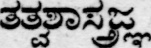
ತತ್ವಶಾಸ್ತ್ರಜ್ಞ
